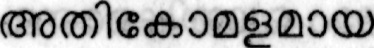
അതികോമളമായ
